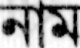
নাম
